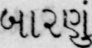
બારણું
